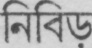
নিবিড়
